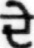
ਦੇ
